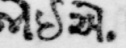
જોઈએ.
